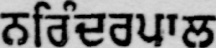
ਨਰਿੰਦਰਪਾਲ
